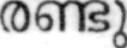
രണ്ടു
